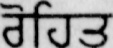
ਰੋਹਿਤ
